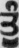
ਤੂੰ
